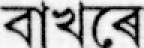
বাখৰে
